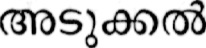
അടുക്കല്‍
